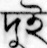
দুই
